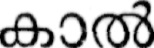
കാല്‍
